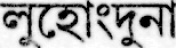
লুহোংদুনা
